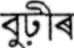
বুঢ়ীৰ
